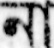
না
